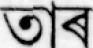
তাৰ
